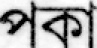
পকা
